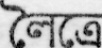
লৈত্রে
